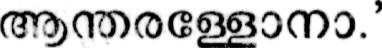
ആന്തരള്ളോനാ.’
